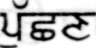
ਪੁੱਛਣ
